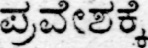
ಪ್ರವೇಶಕ್ಕೆ
